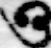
ও
